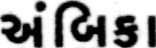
અંબિકા
